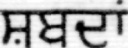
ਸ਼ਬਦਾਂ
